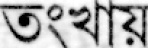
তংখায়
